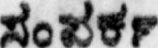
ಸಂಪರ್ಕ
